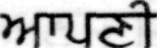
ਆਪਣੀ
